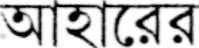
আহারের
